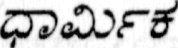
ಧಾರ್ಮಿಕ
